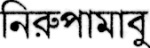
নিরুপামাবু
